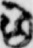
છે
